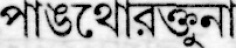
পাঙথোরক্তুনা
